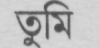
তুমি
